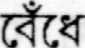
বেঁধে
